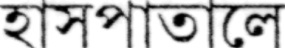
হাসপাতালে
